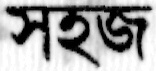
সহজ
